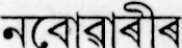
নবোৱাৰীৰ
